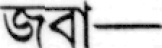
জবা-
